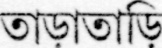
তাড়াতাড়ি
